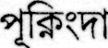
পূক্নিংদা
